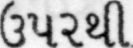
ઉપરથી
